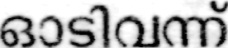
ഓടിവന്ന്
